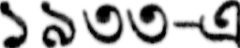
১৯৩৩-এ
